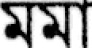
মমা
